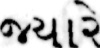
જ્યારે
